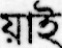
য়াই
